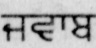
ਜਵਾਬ
